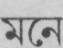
মনে
